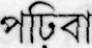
পঢ়িবা
